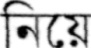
নিয়ে
